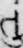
તું
